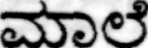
ಮಾಲೆ
